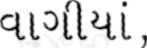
વાગીયાં,
